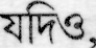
যদিও,
